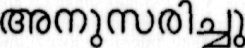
അനുസരിച്ചു
